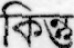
কিন্তু
